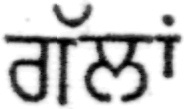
ਗੱਲਾਂ
